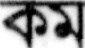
কম
